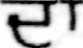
ਦਾ
